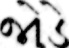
જોડે
